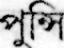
পুন্সি
